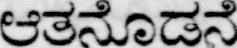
ಆತನೊಡನೆ
